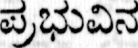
ಪ್ರಭುವಿನ
